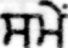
ਸਮੇਂ
